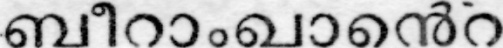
ബീറാംഖാന്റെ
